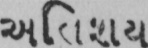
અતિશય
